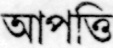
আপত্তি
